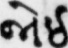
જોઈ
